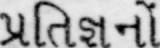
પ્રતિજ્ઞનોં
